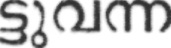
ട്ടുവന്ന
